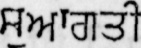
ਸੁਆਗਤੀ
